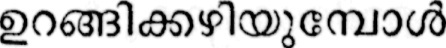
ഉറങ്ങിക്കഴിയുമ്പോള്‍
